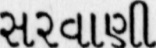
સરવણી
